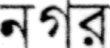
নগর
